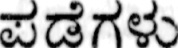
ಪಡೆಗಳು
